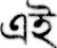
এই
